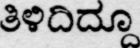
ತಿಳಿದಿದ್ದೂ
